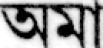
অমা
